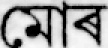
মোৰ
